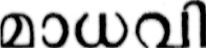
മാധവി
